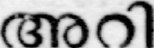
അറി
